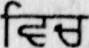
ਵਿਚ
